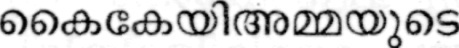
കൈകേയിഅമ്മയുടെ
